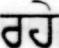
ਰਹੇ
